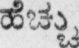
ಹೆಚ್ಚು
